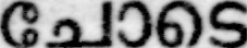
ചോടെ
